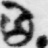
છે.
